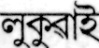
লুকুৱাই
